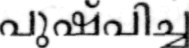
പുഷ്പിച്ച
